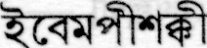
ইবেমপীশক্কী
